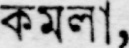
কমলা,
